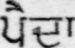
ਪੈਦਾ
